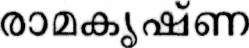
രാമകൃഷ്ണ
